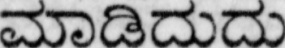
ಮಾಡಿದುದು
